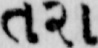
તરા
